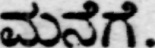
ಮನೆಗೆ.
